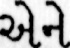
એને
